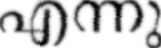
എന്നു
